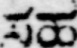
ಸಹ
